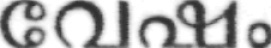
വേഷം
